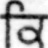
ਕਿ
